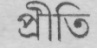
প্ৰীতি
